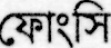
ফোংসি
